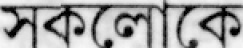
সকলোকে
